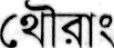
থৌরাং
